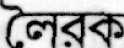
লৈরক
